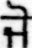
ਜੋ
